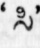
‘ಸಿ'
